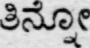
ತಿನ್ನೋ
